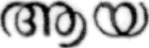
ആയ
